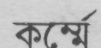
কৰ্ম্মে
